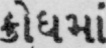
ક્રોધમાં
